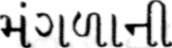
મંગળાની
